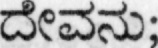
ದೇವನು;
